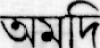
অমদি
